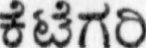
ಕೆಟೆಗರಿ
